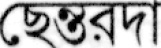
ছেন্তরদা
